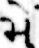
મેં
